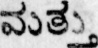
ಮತ್ತು
